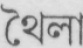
থৈলা
